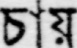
চায়
